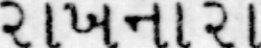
રાખનારા
